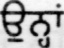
ਉਨ੍ਹਾਂ
